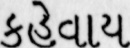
કહેવાય
